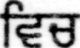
ਵਿਚ
